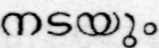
നടയും
